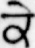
ਕੇ
